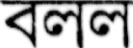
বলল
